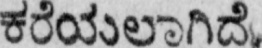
ಕರೆಯಲಾಗಿದೆ.
